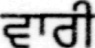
ਵਾਰੀ
